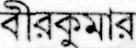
বীরকুমার
